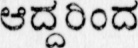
ಆದ್ದರಿಂದ
